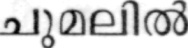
ചുമലില്‍
